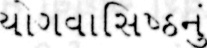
યોગવાસિષ્ઠનું
